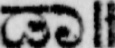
ಡಾ||
